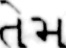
તેમ
